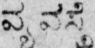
ವ್ಯವಸ್ಥೆ
